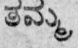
ತಮ್ಮ
